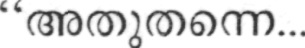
"അതുതന്നെ...
